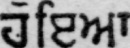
ਹੋਇਆ
